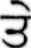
ਤੇ
